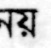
নয়
